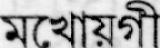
মখোয়গী
